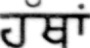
ਹੱਥਾਂ
